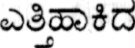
ಎತ್ತಿಹಾಕಿದ
